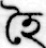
হৈ
